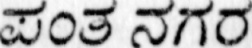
ಪಂತನಗರ
